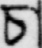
চা
